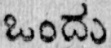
ಒಂದು
